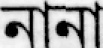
নানা
